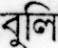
বুলি
